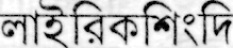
লাইরিকশিংদি
